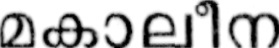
മകാലീന
